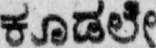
ಕೂಡಲೇ
